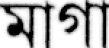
মাগা
